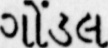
ગોંડલ
